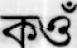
কওঁ
